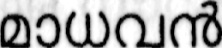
മാധവന്‍
